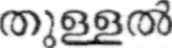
തുള്ളല്‍
